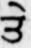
ਤੇ
